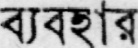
ব্যবহার
